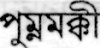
পুম্নমক্কী
